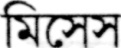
মিসেস
